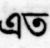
এত
